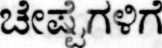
ಚೇಷ್ಟೆಗಳಿಗೆ
